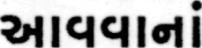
આવવાનાં
